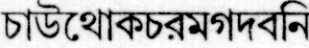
চাউথোকচরমগদবনি
